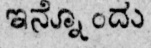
ಇನ್ನೊಂದು
